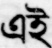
এই
